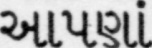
આપણાં
